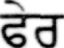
ਫੇਰ
